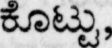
ಕೊಟ್ಟು,
